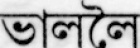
ভাললৈ
